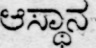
ಆಸ್ಥಾನ
